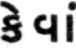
કેવાં
